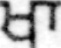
ਖਾ
